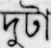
দুটা
